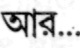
আর...
